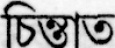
চিন্তাত
